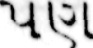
પણ
